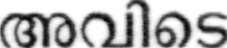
അവിടെ
